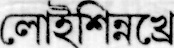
লোইশিন্নখ্রে
